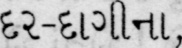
દર-દાગીના,
